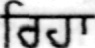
ਰਿਹਾ
